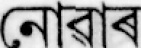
নোৱাৰ
